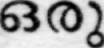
ഒരു
